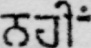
ਨਹੀਂ
